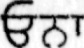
ਓਨਾ
